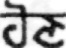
ਹੋਣ
